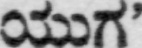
ಯುಗ’
